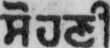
ਸੋਹਣੀ
